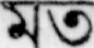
মত
